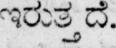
ಇರುತ್ತದೆ.
